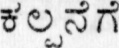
ಕಲ್ಪನೆಗೆ
